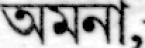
অমনা,
